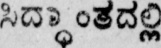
ಸಿದ್ದಾಂತದಲ್ಲಿ
